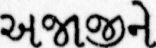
અજાજીને
